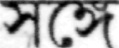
সঙ্গে
